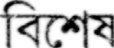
বিশেষ
